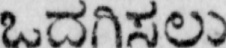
ಒದಗಿಸಲು
